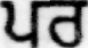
ਪਰ
